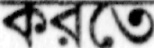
করতে
